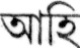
আহি
